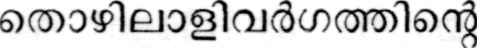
തൊഴിലാളിവര്‍ഗത്തിന്റെ
